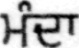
ਮੰਦਾ
